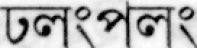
ঢলংপলং
